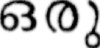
ഒരു
